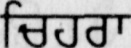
ਚਿਹਰਾ
